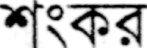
শংকর
